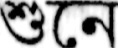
শুনে
